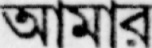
আমার
